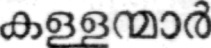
കള്ളന്മാര്‍
